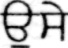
ਉਸੇ
